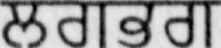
ਲਗਭਗ
